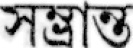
সম্ভ্রান্ত
